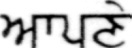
ਆਪਣੇ
